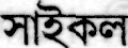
সাইকল
